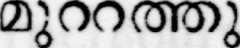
മുററത്തു
